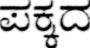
ಪಕ್ಕದ
